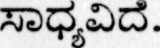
ಸಾಧ್ಯವಿದೆ.
